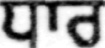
ਧਾਰ
